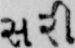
સરી
